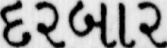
દરબાર
